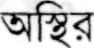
অস্থির
